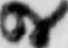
જ
